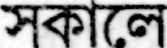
সকালে
